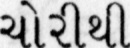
ચોરીથી
